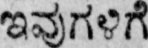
ಇವುಗಳಿಗೆ
